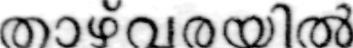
താഴ്വരയില്‍
